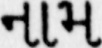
નામ
